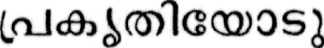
പ്രകൃതിയോടു
